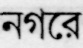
নগরে
